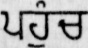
ਪਹੁੰਚ
